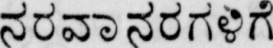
ನರವಾನರಗಳಿಗೆ
